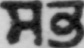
ਸਭ
